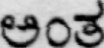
ಅಂತ
